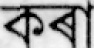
কৰা
